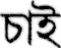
চাই
